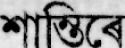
শান্তিৰে
